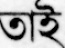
তাই
